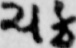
ચક્ર
